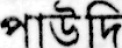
পাউদি
